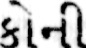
કોની
